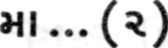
મા........(૨)
